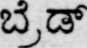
ಬ್ರೆಡ್
